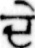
ਦੇ
